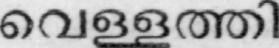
വെള്ളത്തി
